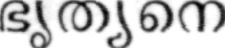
ഭൃത്യനെ
